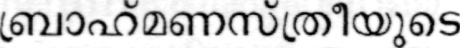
ബ്രാഹ്മണസ്ത്രീയുടെ
